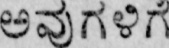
ಅವುಗಳಿಗೆ
